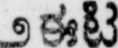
೨ಈಟಿ
